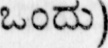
ಒಂದು
